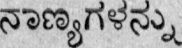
ನಾಣ್ಯಗಳನ್ನು
